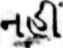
નહીં
